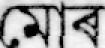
মোৰ
